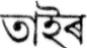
তাইৰ
